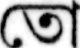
তো
